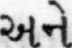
અને
